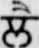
ਲੈ
